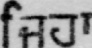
ਜਿਹਾ
